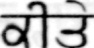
ਕੀਤੇ
